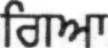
ਗਿਆ
